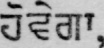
ਹੋਵੇਗਾ,
